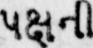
પક્ષની
